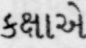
કક્ષાએ
